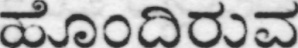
ಹೊಂದಿರುವ
